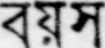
বয়স
